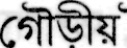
গৌড়ীয়
